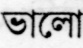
ভালো
